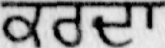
ਕਰਦਾ
